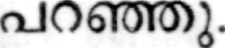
പറഞ്ഞു.
